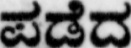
ಪಡೆದ
